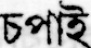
চপাই
